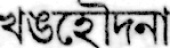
খঙহৌদনা
